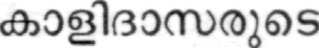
കാളിദാസരുടെ
